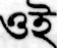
ওই
